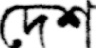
দেশ
